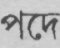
পদে
